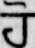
ਹੋ
